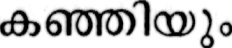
കഞ്ഞിയും
